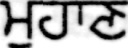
ਮੁਹਾਣ
